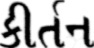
કીર્તન
